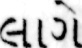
લાગે
